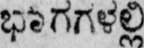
ಭಾಗಗಳಲ್ಲಿ
